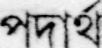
পদার্থ
